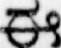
ಈ
